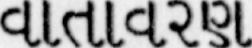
વાતાવરણ
